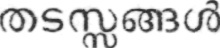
തടസ്സങ്ങള്‍
